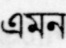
এমন
